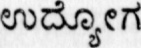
ಉದ್ಯೋಗ
